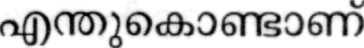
എന്തുകൊണ്ടാണ്
